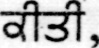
ਕੀਤੀ,
